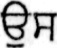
ਉਸ
